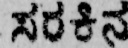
ಸರಕಿನ
